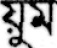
য়ুম
